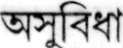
অসুবিধা
